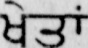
ਖੇਤਾਂ
